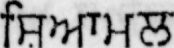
ਸ਼ਿਆਮਲ
